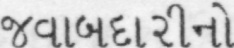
જવાબદારીનો
